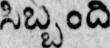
ಸಿಬ್ಬಂದಿ
